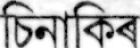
চিনাকিৰ
